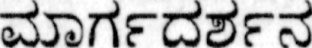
ಮಾರ್ಗದರ್ಶನ
